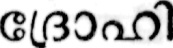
ദ്രോഹി
